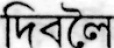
দিবলৈ
